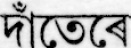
দাঁতেৰে
